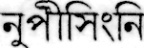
নুপীসিংনি
